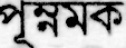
পূস্নমক
